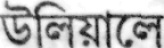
উলিয়ালে
